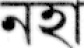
নহা
